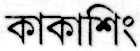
কাকাশিং
